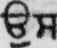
ਉਸ
